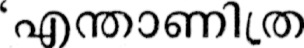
'എന്താണിത്ര
